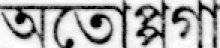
অতোপ্পগা
